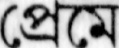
প্রেমে
